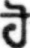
ਹੋ
